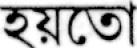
হয়তো
